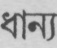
ধান্য
